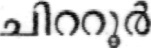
ചിററൂര്‍
